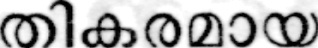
തികരമായ
